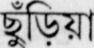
ছুঁড়িয়া
